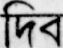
দিব
